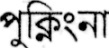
পুক্নিংনা
